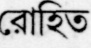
রোহিত
